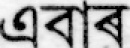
এবাৰ
